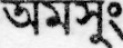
অমসুং
